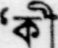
‘কী
